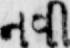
નવી
